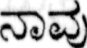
ನಾವು
